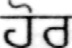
ਹੋਰ
